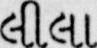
લીલા
